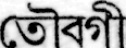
তৌবগী
